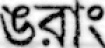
ঙরাং
